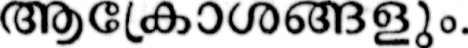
ആക്രോശങ്ങളും.
